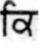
ਕਿ
